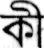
কী
